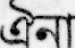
ঐনা
